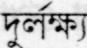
দুর্লক্ষ্য
